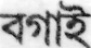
বগাই
